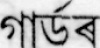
গার্ডৰ
